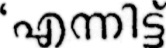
‘എന്നിട്ട്
